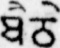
ਬੈਠੇ
